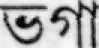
ভগা
